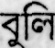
বুলি
